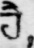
ਹੈ,
